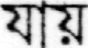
যায়
